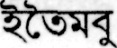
ইতৈমবু
